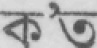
ক'ত
